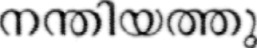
നന്തിയത്തു
